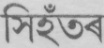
সিহঁতৰ
